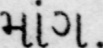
માંગ.
